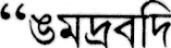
“ঙমদ্রবদি
